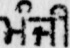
ਮੰਜੀ
